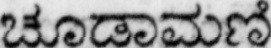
ಚೂಡಾಮಣಿ
